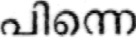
പിന്നെ
